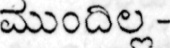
ಮುಂದಿಲ್ಲ-
